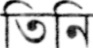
তিনি
